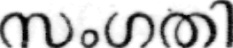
സംഗതി
